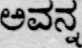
ಅವನ್ನ
